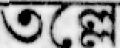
তল্লে
